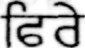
ਫਿਰੇ
